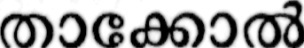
താക്കോല്‍
